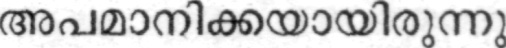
അപമാനിക്കയായിരുന്നു
